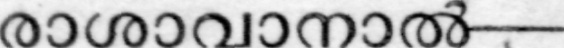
രാശാവാനാല്‍-
